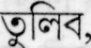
তুলিব,
